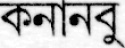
কনানবু
